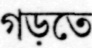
গড়তে
